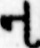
ન
